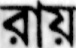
রায়
